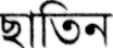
ছাতিন
